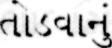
તોડવાનું
